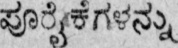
ಪೂರೈಕೆಗಳನ್ನು
